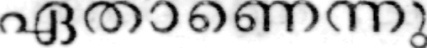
ഏതാണെന്നു
